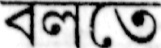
বলতে
